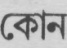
কোন
